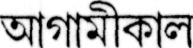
আগামীকাল
